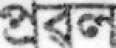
প্ৰৱল
